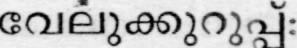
വേലുക്കുറുപ്പ്:
